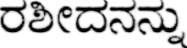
ರಶೀದನನ್ನು
